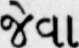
જેવા
